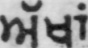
ਅੱਖਾਂ
